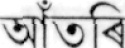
আঁতৰি
